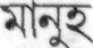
মানুহ
